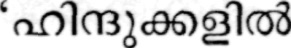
'ഹിന്ദുക്കളില്‍
